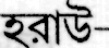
হরাউ-
